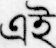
এই
